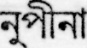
নুপীনা
